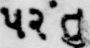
પરંતુ
